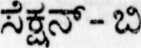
ಸೆಕ್ಷನ್-ಬಿ
